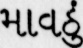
માવઠું
